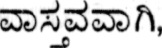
ವಾಸ್ತವವಾಗಿ,
